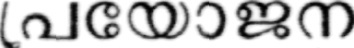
പ്രയോജന
